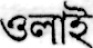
ওলাই
